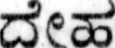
ದೇಹ
